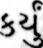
કર્યું
